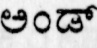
ಅಂಡ್
